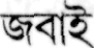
জবাই
